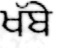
ਖੱਬੇ
